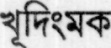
খূদিংমক
